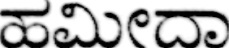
ಹಮೀದಾ
